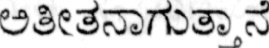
ಅತೀತನಾಗುತ್ತಾನೆ
